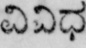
ವಿವಿಧ
